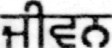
ਜੀਵਨ
